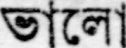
ভালো
